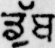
ਡੁੱਬ
